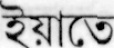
ইয়াতে
